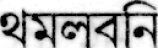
থমলবনি
